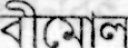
বীমোল
